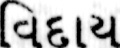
વિદાય
